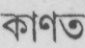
কাণত
